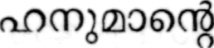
ഹനുമാന്റെ
